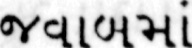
જવાબમાં
